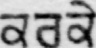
ਕਰਕੇ
